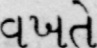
વખતે
